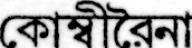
কোম্বীরৈনা
